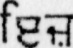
ਇਜ਼
